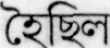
হৈছিল
